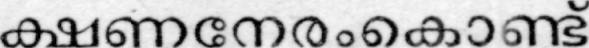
ക്ഷണനേരംകൊണ്ട്
